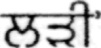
ਲੜੀ'
